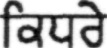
ਕਿਧਰੇ
